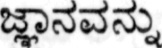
ಜ್ಞಾನವನ್ನು
